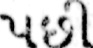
પછી
